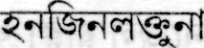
হনজিনলক্তুনা
